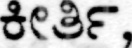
ಕೀರ್ತಿ,
